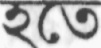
হতে
